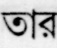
তার
